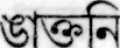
ঙাক্তনি
